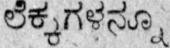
ಲೆಕ್ಕಗಳನ್ನೂ
